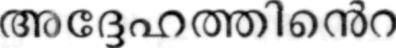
അദ്ദേഹത്തിന്റെ
